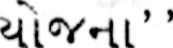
યોજના"
